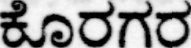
ಕೊರಗರ
